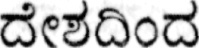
ದೇಶದಿಂದ
